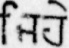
ਜਿਹੇ
